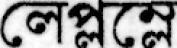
লেপ্লম্লে
